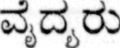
ವೈದ್ಯರು
